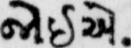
જોઈએ.
